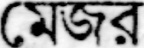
মেজর
